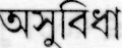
অসুবিধা
